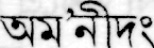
অম’নীদং
